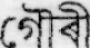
গৌৰী
